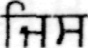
ਜਿਸ
